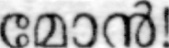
മോന്‍!
